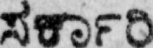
ಸರ್ಕಾರಿ
